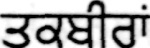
ਤਕਬੀਰਾਂ
